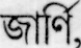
জার্ণি,
